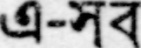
এ-সব
